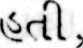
હતી,
